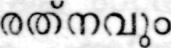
രത്നവും
